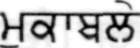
ਮੁਕਾਬਲੇ
